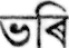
ভৰি
